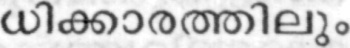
ധിക്കാരത്തിലും
